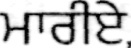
ਮਾਰੀਏ,
